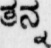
ತನ್ನ
